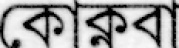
কোক্নবা
